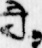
ਹੈ,
